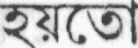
হয়তো
